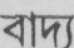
বাদ্য
